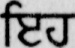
ਇਹ
